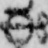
ಈ
